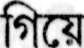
গিয়ে
